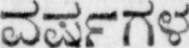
ವರ್ಷಗಳ
